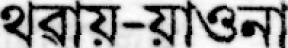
থৱায়-য়াওনা
